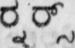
ರ್‍ನರ್‍ಸ್
